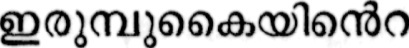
ഇരുമ്പുകൈയിന്റെ
